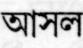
আসল
